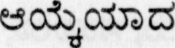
ಆಯ್ಕೆಯಾದ
